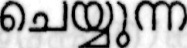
ചെയ്യുന്ന
